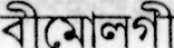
বীমোলগী
